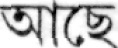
আছে
